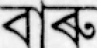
বাৰু
